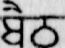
ਬੈਠ
